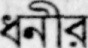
ধনীর
